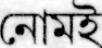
নোমই
